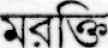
মরক্তি
